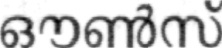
ഔണ്‍സ്
